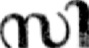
സി
